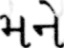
મને
